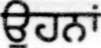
ਉਹਨਾਂ
